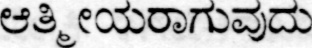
ಆತ್ಮೀಯರಾಗುವುದು
